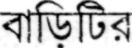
বাড়িটির
